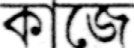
কাজে
